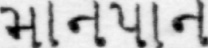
માનપાન
